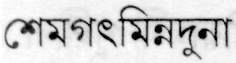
শেমগৎমিন্নদুনা
